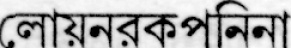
লোয়নরকপনিনা
